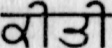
ਕੀਤੀ
